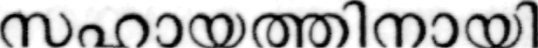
സഹായത്തിനായി
